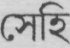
সেহি
